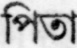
পিতা
